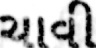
ચાવી
